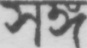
সঙ্গ
